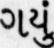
ગયું
